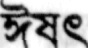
ঈষৎ
